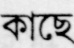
কাছে
